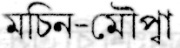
মচিন-মৌপ্বা
